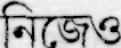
নিজেও
